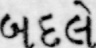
બદલે
